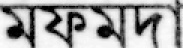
মফমদা
